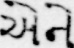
એને
